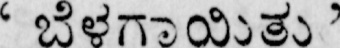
‘ಬೆಳಗಾಯಿತು’
